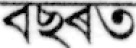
বছৰত
